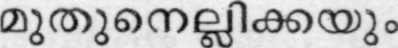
മുതുനെല്ലിക്കയും
